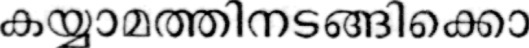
കയ്യാമത്തിനടങ്ങിക്കൊ
